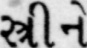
સ્ત્રીને
